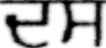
ਦਸ
